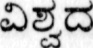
ವಿಶ್ವದ
